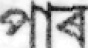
পাৰ
